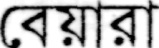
বেয়ারা
